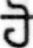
ਹੋ
